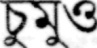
চুমুও
